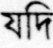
যদি
